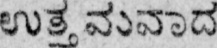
ಉತ್ತಮವಾದ
